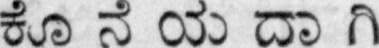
ಕೊನೆಯದಾಗಿ
